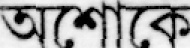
অশোকে
